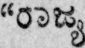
“ರಾಜ್ಯ
